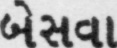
બેસવા
